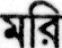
মরি
